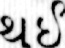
થઈ
